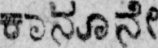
ಕಾನೂನೇ
